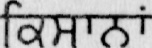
ਕਿਸਾਨਾਂ
